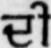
ਦੀ
